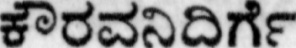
ಕೌರವನಿದಿರ್ಗೆ
